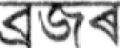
ব্ৰজৰ
